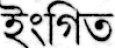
ইংগিত
